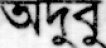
অদুবু
